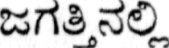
ಜಗತ್ತಿನಲ್ಲಿ
